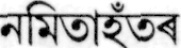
নমিতাহঁতৰ
